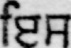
ਇਸ
